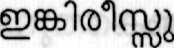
ഇങ്കിരീസ്സു
